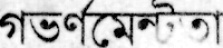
গভর্নমেন্টতা
